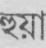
হুয়া
